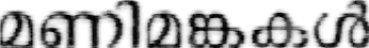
മണിമങ്കകള്‍
